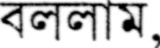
বললাম,
